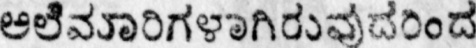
ಅಲೆಮಾರಿಗಳಾಗಿರುವುದರಿಂದ
